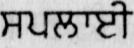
ਸਪਲਾਈ
